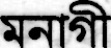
মনাগী
